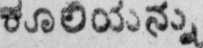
ಕೂಲಿಯನ್ನು
